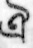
ঐ
